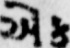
એક
